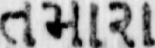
તમારા
